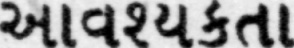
આવશ્યકતા
